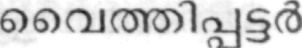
വൈത്തിപ്പട്ടര്‍
